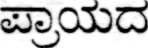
ಪ್ರಾಯದ
